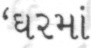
'ઘરમાં
